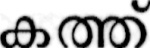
കത്ത്
